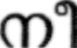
നീ
